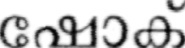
ഷോക്
